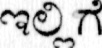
ಇಲ್ಲಿಗೆ
